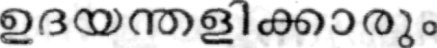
ഉദയന്തളിക്കാരും
